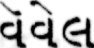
વૅવેલ
